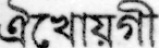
ঐখোয়গী
